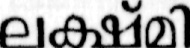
ലക്ഷ്മി
